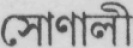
সোণালী
